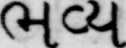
ભવ્ય
